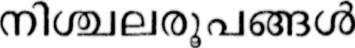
നിശ്ചലരൂപങ്ങള്‍
